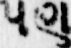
પણ
